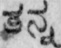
ತನ್ನ
